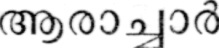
ആരാച്ചാര്‍
